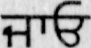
ਜਾਓ
